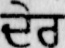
ਦੇਰ
